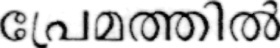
പ്രേമത്തില്‍
